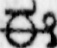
ಈ
